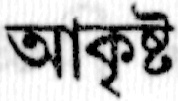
আকৃষ্ট
